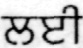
ਲਈ
